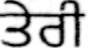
ਤੇਰੀ
